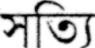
সত্যি
